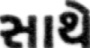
સાથે
